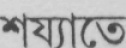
শয্যাতে
